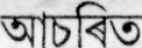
আচৰিত
